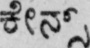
ಕೇನ್ಸ್
